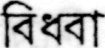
বিধবা
